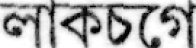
লাকচগে
